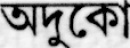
অদুকো
